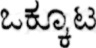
ಒಕ್ಕೊಟ
